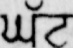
ਘੱਟ
